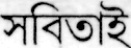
সবিতাই
